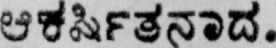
ಆಕರ್ಷಿತನಾದ.
